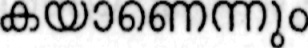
കയാണെന്നും
